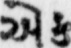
એક
